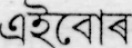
এইবোৰ
